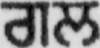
ਗਲ
